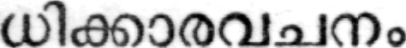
ധിക്കാരവചനം
